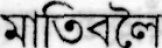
মাতিবলৈ
